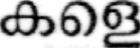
കളെ
